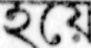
হয়ে
